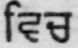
ਵਿਚ
